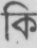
কি
